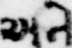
અને
